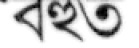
'বহুত
